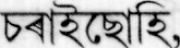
চৰাইছোহি,
